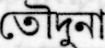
তৌদুনা
